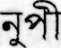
নুপী
